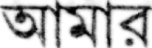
আমার
